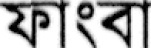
ফাংবা
